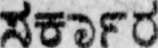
ಸರ್ಕಾರ
